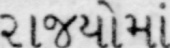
રાજ્યોમાં
